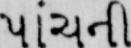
પાંચની
